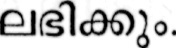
ലഭിക്കും.
